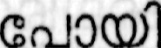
പോയി
